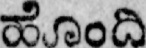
ಹೊಂದಿ
